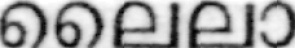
ലൈലാ
